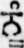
ਨੂੰ
